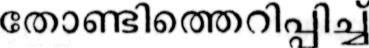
തോണ്ടിത്തെറിപ്പിച്ച്
